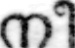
നീ
